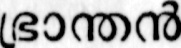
ഭ്രാന്തന്‍
